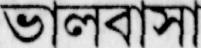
ভালবাসা
